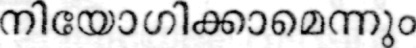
നിയോഗിക്കാമെന്നും
